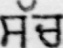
ਸੱਚ
